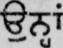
ਉਨ੍ਹਾਂ
